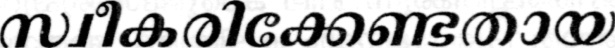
സ്വീകരിക്കേണ്ടതായ
